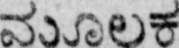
ಮೂಲಕ
